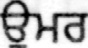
ਉਮਰ
